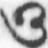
ও
